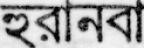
হুরানবা
